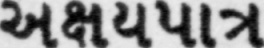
અક્ષયપાત્ર
